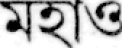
মহাও
